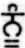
ਨੂੰ
